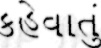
કહેવાતું
